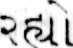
રહ્યો
